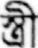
স্ত্রী
